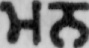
ਮਨ
